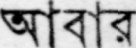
আবার
